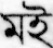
মই
